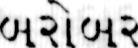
બરોબર
